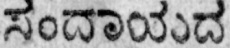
ಸಂದಾಯದ
